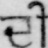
ਦੀ
